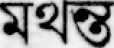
মথন্ত
